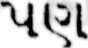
પણ
